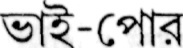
ভাই-পোর
